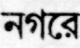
নগরে
